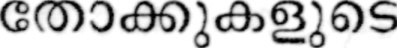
തോക്കുകളുടെ
